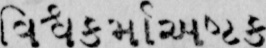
વિશ્વકર્માઅષ્ટક
